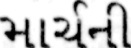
માર્ચની
